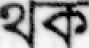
থক
